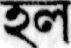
হল
